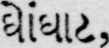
ઘોંઘાટ,
